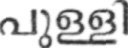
പുള്ളി
